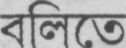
বলিতে
